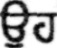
ਉਹ
